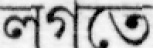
লগতে
